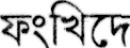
ফংখিদে
